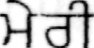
ਮੇਰੀ
